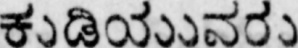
ಕುಡಿಯುವರು
